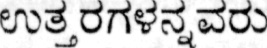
ಉತ್ತರಗಳನ್ನವರು
